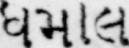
ધમાલ
